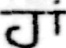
ਹਾਂ
